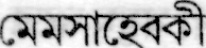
মেমসাহেবকী
